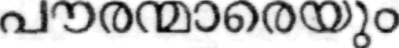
പൌരന്മാരെയും
